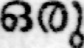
ഒരു
